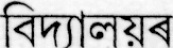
বিদ্যালয়ৰ
